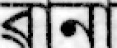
ৱানা
